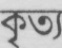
কৃত্য
